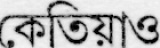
কেতিয়াও
